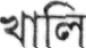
খালি
